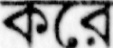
করে
